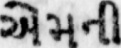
એમની
